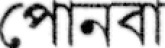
পোনবা
